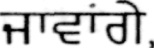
ਜਾਵਾਂਗੇ,
